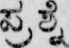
ಪ್ರಶ್ನೆ
